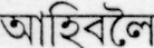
আহিবলৈ
